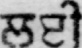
ਲਈ
